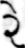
રે
